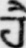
ਹੈ
